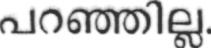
പറഞ്ഞില്ല.
